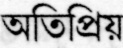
অতিপ্রিয়
